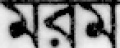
মরম
